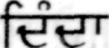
ਦਿੰਦਾ
